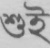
শুই
